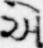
એ
